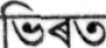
ভিৰত
